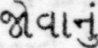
જોવાનું
